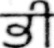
ਭੀ
